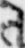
તે
